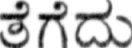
ತೆಗೆದು
